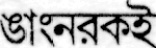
ঙাংনরকই
